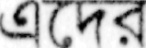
এদের
